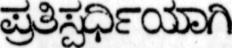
ಪ್ರತಿಸ್ಪರ್ಧಿಯಾಗಿ
